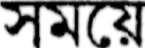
সময়ে
